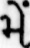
મેં
